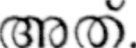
അത്.
